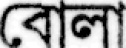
বোলা
